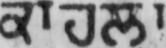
ਕਾਹਲਾ
